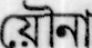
য়ৌনা
